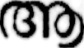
ആ
